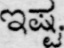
ಇಷ್ಟ.
